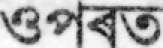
ওপৰত
